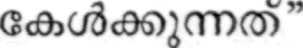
കേള്‍ക്കുന്നത്”
